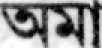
অমা
